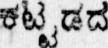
ಕಟ್ಟಡದ
